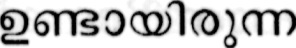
ഉണ്ടായിരുന്ന
